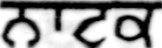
ਨਾਟਕ
